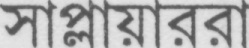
সাপ্লায়াররা
